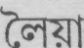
লৈয়া
